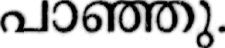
പാഞ്ഞു.
